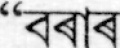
"বৰাৰ
